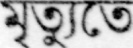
মৃত্যুতে
